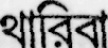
থারিবা
